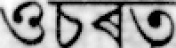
ওচৰত
